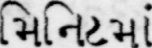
મિનિટમાં
